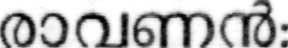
രാവണന്‍:
